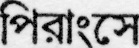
পিরাংসে
